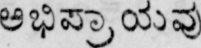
ಅಭಿಪ್ರಾಯವು
